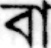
বা
